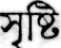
সৃষ্টি
